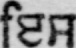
ਇਸ
